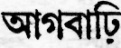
আগবাঢ়ি
